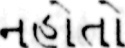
નહોતો
